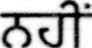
ਨਹੀਂ
